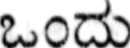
ಒಂದು
